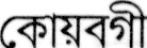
কোয়বগী
